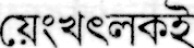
য়েংখৎলকই
